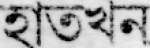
হাতখন
